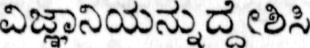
ವಿಜ್ಞಾನಿಯನ್ನುದ್ದೇಶಿಸಿ
